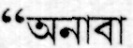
“অনাবা
